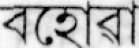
বহোৱা
